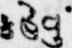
કહેવું
